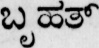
ಬೃಹತ್
